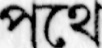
পথে
